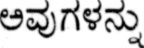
ಅವುಗಳನ್ನು
